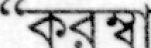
“করম্বা
